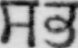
ਸਭ
